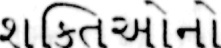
શક્તિઓનો
